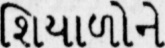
શિયાળોને
